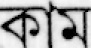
কাম
